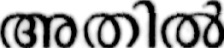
അതില്‍
